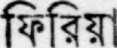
ফিরিয়া
